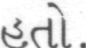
હતો.
